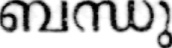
ബന്ധു
